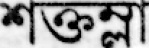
শক্তম্লা
